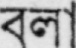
বলা
